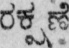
ರಕ್ಷಣೆ
